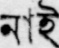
নাই
